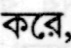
করে,
